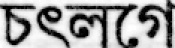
চৎলগে
